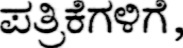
ಪತ್ರಿಕೆಗಳಿಗೆ,
